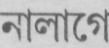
নালাগে
